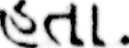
હતા.
